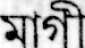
মাগী
